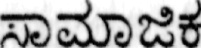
ಸಾಮಾಜಿಕ
